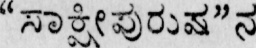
“ಸಾಕ್ಷೀಪುರುಷ”ನ
